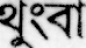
থুংবা
